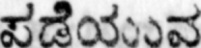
ಪಡೆಯುವ
